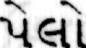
પેલો
